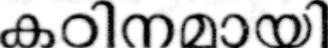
കഠിനമായി
